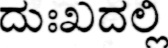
ದುಃಖದಲ್ಲಿ
